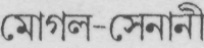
মোগল-সেনানী
